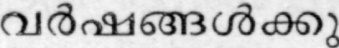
വര്‍ഷങ്ങള്‍ക്കു
